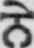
ਨੇ
